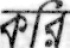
করি
